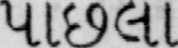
પાછલા
